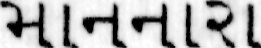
માનનારા
